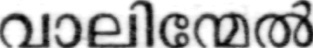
വാലിന്മേല്‍
